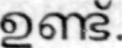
ഉണ്ട്.
